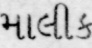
માલીક
